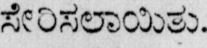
ಸೇರಿಸಲಾಯಿತು.
